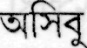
অসিবু
